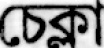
চেক্লা
